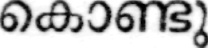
കൊണ്ടു
